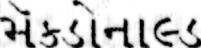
મૅક્ડોનાલ્ડ
